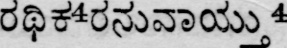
ರಥಿಕ4ರನುವಾಯ್ತು4
